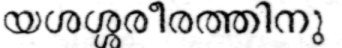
യശശ്ശരീരത്തിനു
